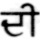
ਦੀ
